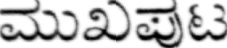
ಮುಖಪುಟ
